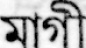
মাগী
